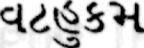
વટહુકમ
